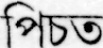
পিচত
